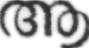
ആ
